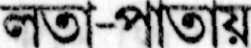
লতা-পাতায়
